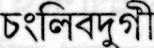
চংলিবদুগী
